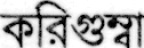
করিগুম্বা
